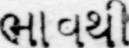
ભાવથી
